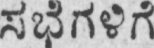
ಸಭೆಗಳಿಗೆ
